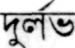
দুর্লভ
